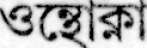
ওন্থোক্না
